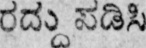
ರದ್ದುಪಡಿಸಿ
